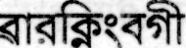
ৱারক্নিংবগী
